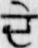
ਦੇ
